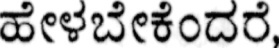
ಹೇಳಬೇಕೆಂದರೆ,
